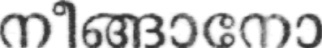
നീങ്ങാനോ
